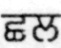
ਛਲ
